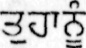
ਤੁਹਾਨੂੰ
